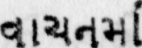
વાચનમાં
